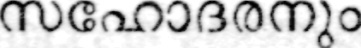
സഹോദരനും
